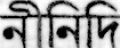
নীনিদি
